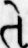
તે
